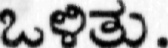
ಒಳಿತು.
